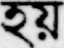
হয়
